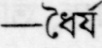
–ধৈর্য
